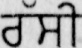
ਰੱਸੀ
